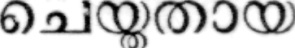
ചെയ്തതായ
